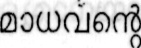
മാധവന്റെ
